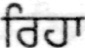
ਰਿਹਾ
